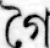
গৈ
